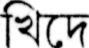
খিদে
